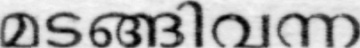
മടങ്ങിവന്ന
